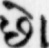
છો
